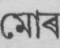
মোৰ
